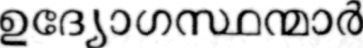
ഉദ്യോഗസ്ഥന്മാര്‍
